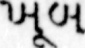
ખૂબ
